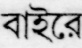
বাইরে
